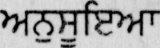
ਅਨੁਸੂਇਆ
